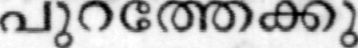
പുറത്തേക്കു
